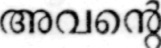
അവന്റെ
